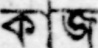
কাজ
